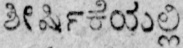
ಶೀರ್ಷಿಕೆಯಲ್ಲಿ
